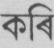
কৰি
